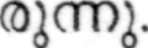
രുന്നു.
